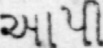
આપી
